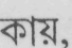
কায়,
